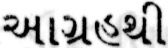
આગ્રહથી
